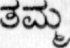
ತಮ್ಮ
